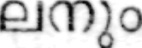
ലനും
